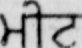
ਮੀਟ
